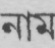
নাম
